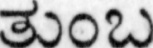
ತುಂಬ
